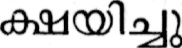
ക്ഷയിച്ചു
